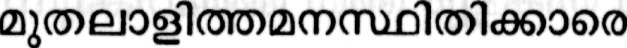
മുതലാളിത്തമനസ്ഥിതിക്കാരെ
